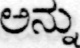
ಅನ್ನು
